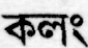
কলং
